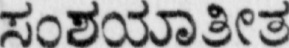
ಸಂಶಯಾತೀತ
